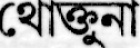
থোক্তুনা
